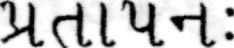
પ્રતાપનઃ
